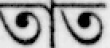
তাত
